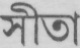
সীতা
